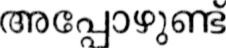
അപ്പോഴുണ്ട്
